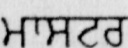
ਮਾਸਟਰ
